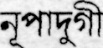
নূপাদুগী
